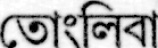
তোংলিবা
